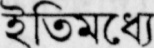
ইতিমধ্যে
